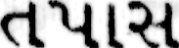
તપાસ
